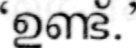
'ഉണ്ട്.'
